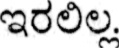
ಇರಲಿಲ್ಲ.
